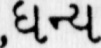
ધન્ય
